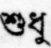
শুধু
